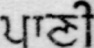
ਪਾਣੀ
